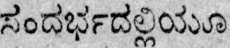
ಸಂದರ್ಭದಲ್ಲಿಯೂ
